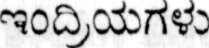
ಇಂದ್ರಿಯಗಳು
